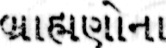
બ્રાહ્મણોના
